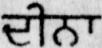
ਦੀਨਾ
